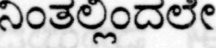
ನಿಂತಲ್ಲಿಂದಲೇ
